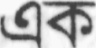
এক
